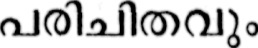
പരിചിതവും
